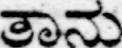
ತಾನು
